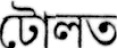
টোলত
